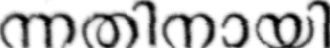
ന്നതിനായി
